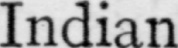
Indian
